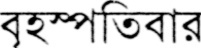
বৃহস্পতিবার
